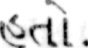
હતો.
